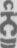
ਨੂੰ
